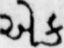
એક
